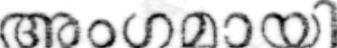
അംഗമായി
